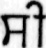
ਸੀ
